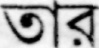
তার
